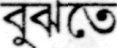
বুঝতে
